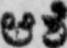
ಆಶೆ
